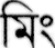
মিং
